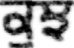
ਕੁਝ
